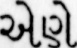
એણે
